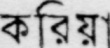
করিয়া
